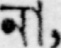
না,
